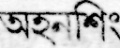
অহনশিং
